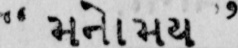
“મનોમય"
